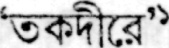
‘তকদীরে’১
